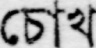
চোখ
